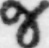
જ
